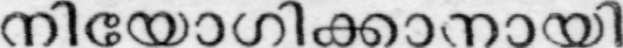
നിയോഗിക്കാനായി
